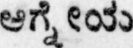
ಆಗ್ನೇಯ
